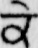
ਕੇ
